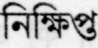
নিক্ষিপ্ত
